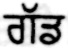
ਗੱਡ
